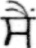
ਸੈਂ
